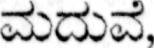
ಮದುವೆ,
